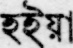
হইয়া
